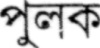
পুলক
